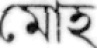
মোহ
